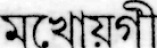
মখোয়গী
